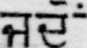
ਜਦੋਂ
